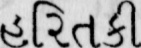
હરિતકી
